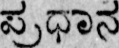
ಪ್ರಧಾನ
